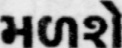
મળશે
